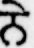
ਨੇ
